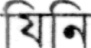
যিনি
